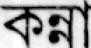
কন্না
